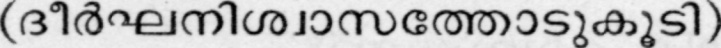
(ദീര്‍ഘനിശ്വാസത്തോടുകൂടി)
